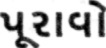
પૂરાવો
